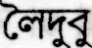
লৈদুবু
